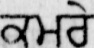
ਕਮਰੇ
